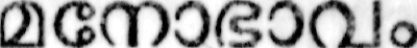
മനോഭാവം
